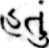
હતું
